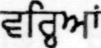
ਵਰ੍ਹਿਆਂ
